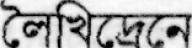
লৈখিদ্রেনে
